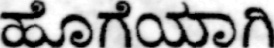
ಹೊಗೆಯಾಗಿ
